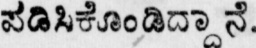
ಪಡಿಸಿಕೊಂಡಿದ್ದಾನೆ.
